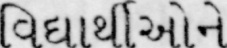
વિદ્યાર્થીઓને
